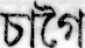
চাগৈ
